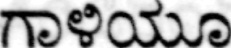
ಗಾಳಿಯೂ
